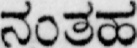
ನಂತಹ
